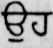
ਉਹ
